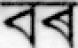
বৰ
